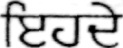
ਇਹਦੇ
